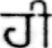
ਹੀ
